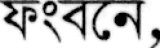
ফংবনে,
